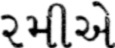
રમીએ
